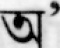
অ'
